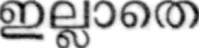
ഇല്ലാതെ
